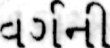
વર્ગની
